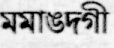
মমাঙদগী
